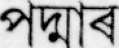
পদ্মাৰ
